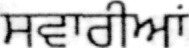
ਸਵਾਰੀਆਂ
